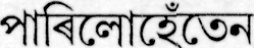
পাৰিলোহেঁতেন
